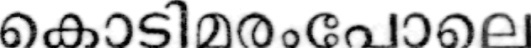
കൊടിമരംപോലെ
